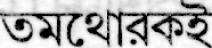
তমথোরকই
